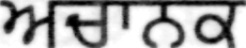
ਅਚਾਨਕ
